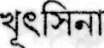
খূৎসিনা
